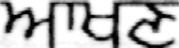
ਆਖਣ
